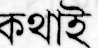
কথাই
